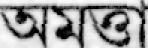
অমত্তা
